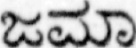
ಜಮಾ
